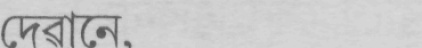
দেৱানে,
